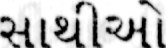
સાથીઓ
